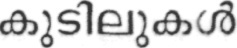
കുടിലുകള്‍
